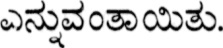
ಎನ್ನುವಂತಾಯಿತು.
